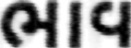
ભાવ
